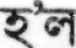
হ'ল
